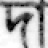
দা
